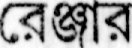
রেঞ্জার
